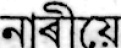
নাৰীয়ে
